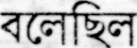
বলেছিল
